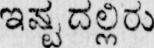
ಇಷ್ಟದಲ್ಲಿರು
